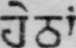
ਹੇਠਾਂ
